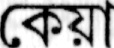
কেয়া
